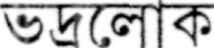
ভদ্রলোক
